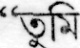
"তুমি
